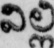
ವಿಲ್ಲಿ
